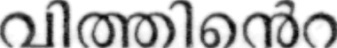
വിത്തിന്റെ
